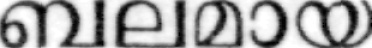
ബലമായ
